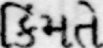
કિંમતે
